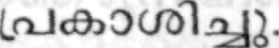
പ്രകാശിച്ചു.
